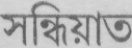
সন্ধিয়াত
